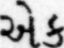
એક
